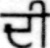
ਦੀ
